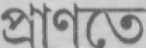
প্ৰাণতে
